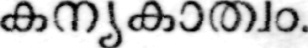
കന്യകാത്വം.
